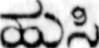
ಹುಸಿ
